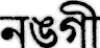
নঙগী
